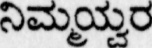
ನಿಮ್ಮಯ್ವರ
